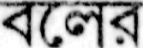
বলের
